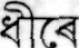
ধীৰে
